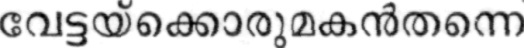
വേട്ടയ്ക്കൊരുമകന്‍തന്നെ
